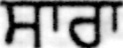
ਸਾਰਾ
